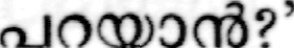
പറയാന്‍?'
